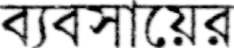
ব্যবসায়ের
